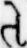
તે
